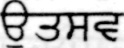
ਉਤਸਵ
